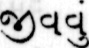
જીવવું
